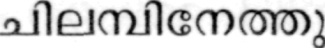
ചിലമ്പിനേത്തു
